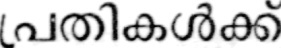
പ്രതികള്‍ക്ക്
